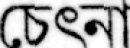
চেৎনা
